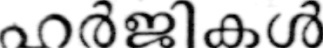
ഹര്‍ജികള്‍
